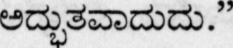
ಅದ್ಭುತವಾದುದು."
